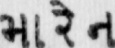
મારેન
